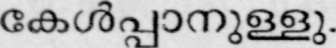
കേള്‍പ്പാനുള്ളു.
